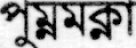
পুম্নমক্না
